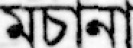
মচানা
